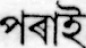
পৰাই
